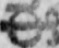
ಈ
